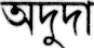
অদুদা
